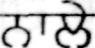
ਨਾਲੇ
